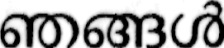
ഞങ്ങള്‍
